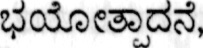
ಭಯೋತ್ಪಾದನೆ,
